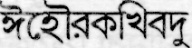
ঈহৌরকখিবদু
